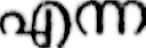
എന്ന
